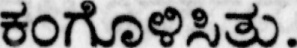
ಕಂಗೊಳಿಸಿತು.
